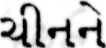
ચીનને
